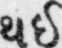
થઈ
